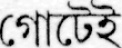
গোটেই
